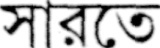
সারতে
